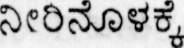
ನೀರಿನೊಳಕ್ಕೆ
